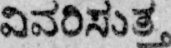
ವಿವರಿಸುತ್ತ
